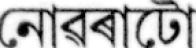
নোৱৰাটো
